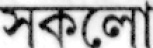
সকলো
